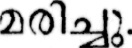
മരിച്ചു.
